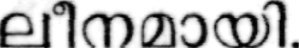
ലീനമായി.
